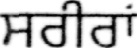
ਸਰੀਰਾਂ
